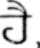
ਹੈ,
